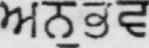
ਅਨੁਭਵ
